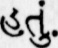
હતું.
